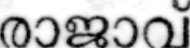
രാജാവ്
